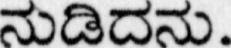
ನುಡಿದನು.
